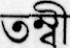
তম্বী
